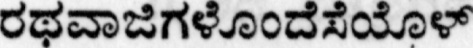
ರಥವಾಜಿಗಳೊಂದೆಸೆಯೊಳ್
